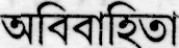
অবিবাহিতা
